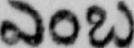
ಎಂಬ
